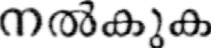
നല്‍കുക
